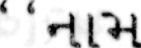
"નામ
